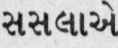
સસલાએ
